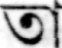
তা
